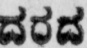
ದರದ
